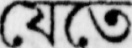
যেতে
